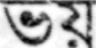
ভয়
